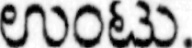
ಉಂಟು.
